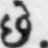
છે.
